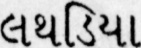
લથડિયા
